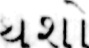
થશો
